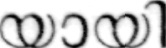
യായി
